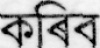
কৰিব
